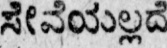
ಸೇವೆಯಲ್ಲದೆ
